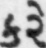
કરે
